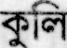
কুলি
